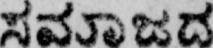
ಸಮಾಜದ
